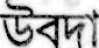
উবদা
